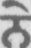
ਨੇ
